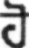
ਹੋ
